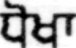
ਧੋਖਾ
